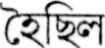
হৈছিল
